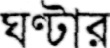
ঘণ্টার
